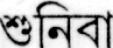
শুনিবা
